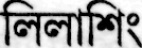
লিলাশিং
